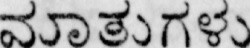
ಮಾತುಗಳು
